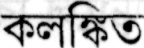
কলঙ্কিত
